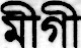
মীগী
